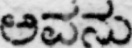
ಅವನು
